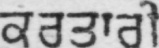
ਕਰਤਾਰੀ
